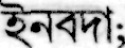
ইনবদা;
